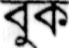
বুক
